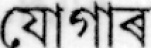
যোগাৰ
